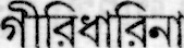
গীরিধারিনা
